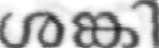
ശങ്കി
